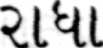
રાધા
